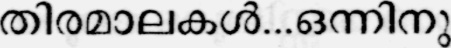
തിരമാലകള്‍...ഒന്നിനു
